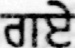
ਗਏ
